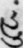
હું
